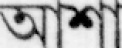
আশা
